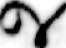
જ
